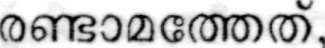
രണ്ടാമത്തേത്,
